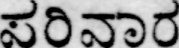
ಪರಿವಾರ
